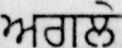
ਅਗਲੇ
